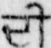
ਦੀ
